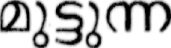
മുട്ടുന്ന
